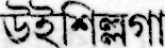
উইশিল্লগা
